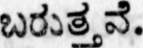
ಬರುತ್ತವೆ.
